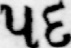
પદ
